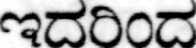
ಇದರಿಂದ
